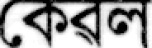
কেৱল
